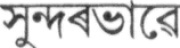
সুন্দৰভাৱে
